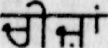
ਚੀਜ਼ਾਂ
